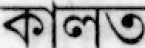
কালত
